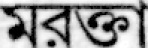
মরক্তা
